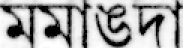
মমাঙদা
